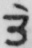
ਤੇ
